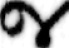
જ
